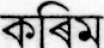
কৰিম
